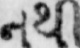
નથી
